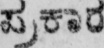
ಪ್ರಕಾರ
